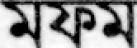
মফম
